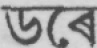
ডৰে
